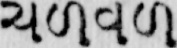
ચળવળ
